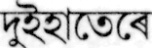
দুইহাতেৰে
